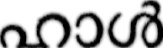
ഹാള്‍
